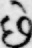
છે
